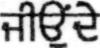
ਜੀਉਂਦੇ
